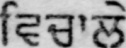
ਵਿਚਾਲੇ
